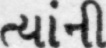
ત્યાંની
